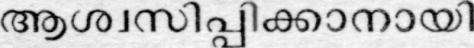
ആശ്വസിപ്പിക്കാനായി
